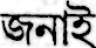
জনাই
